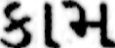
કામ
